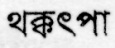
থক্কৎপা
